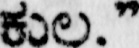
ಕುಲ.”
